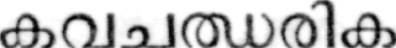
കവചത്സരിക
